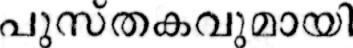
പുസ്തകവുമായി
